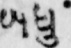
બધું
